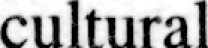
cultural
